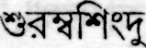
শুরম্বশিংদু
